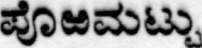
ಪೊಱಮಟ್ಟು
